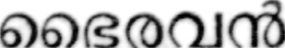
ഭൈരവന്‍
